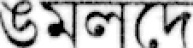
ঙমলদে
